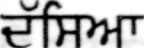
ਦੱਸਿਆ
